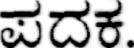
ಪದಕ.
